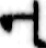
ન
